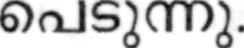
പെടുന്നു.
